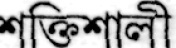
শক্তিশালী
